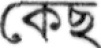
কেছ
